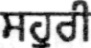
ਸਹੁਰੀ
